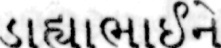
ડાહ્યાભાઈને
